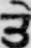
ਤੇ
